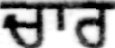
ਚਾਰ
